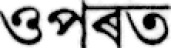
ওপৰত
